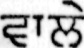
ਵਾਲੇ
